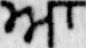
ਆ
